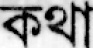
কথা
